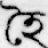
হৈ
